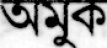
অমুক
